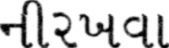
નીરખવા
